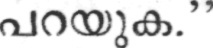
പറയുക."
